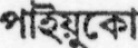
পাইয়ুকো
